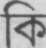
কি
